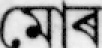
মোৰ
